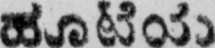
ಹೂಟೆಯ
